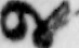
જ
